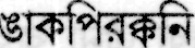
ঙাকপিরক্কনি
